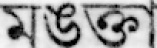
মঙক্তা
